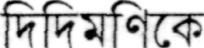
দিদিমণিকে
